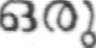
ഒരു
